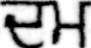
ਦਮ
